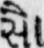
સૌ
